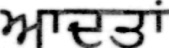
ਆਦਤਾਂ
